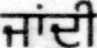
ਜਾਂਦੀ
